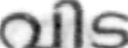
വിട
